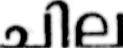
ചില
